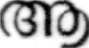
ആ
